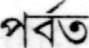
পর্বত
